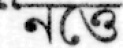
“নত্তে
